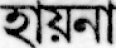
হায়না
